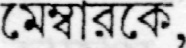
মেম্বারকে,
